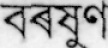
বৰষুণ
